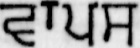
ਵਾਪਸ
